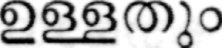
ഉള്ളതും
